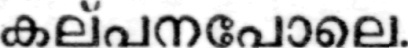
കല്പനപോലെ.
